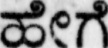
ಹೇಗೆ
